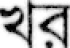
খরা
